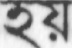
হয়
